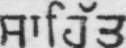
ਸਾਹਿੱਤ
